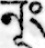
নূং
